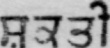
ਸ਼ਕਤੀ
